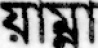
য়াম্না
